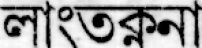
লাংতক্ননা
